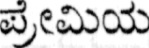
ಪ್ರೇಮಿಯ
